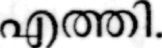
എത്തി.
